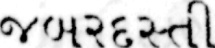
જબરદસ્તી
